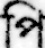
পি
